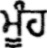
ਮੂੰਹ
